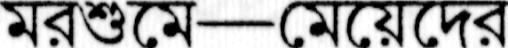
মরশুমে-মেয়েদের
